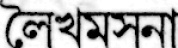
লৈখমসনা
